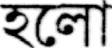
হলো
